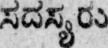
ಸದಸ್ಯರು
